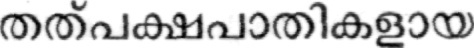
തത്പക്ഷപാതികളായ
